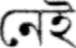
নেই
